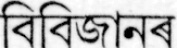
বিবিজানৰ
